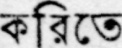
করিতে
